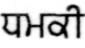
ਧਮਕੀ
